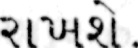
રાખશે.
